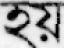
হয়
